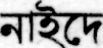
নাইতে
